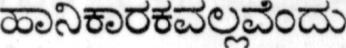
ಹಾನಿಕಾರಕವಲ್ಲವೆಂದು
